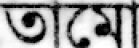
তামো
